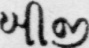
બીજી
